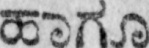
ಹಾಗೂ
